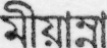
মীয়াম্না
